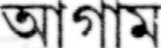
আগাম
